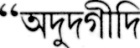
“অদুদগীদি
